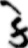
કે
